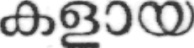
കളായ
